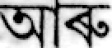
আৰু
